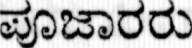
ಪೂಜಾರರು
